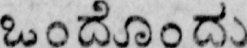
ಒಂದೊಂದು
